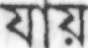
যায়
